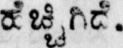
ಹೆಚ್ಚಿಗಿದೆ.
